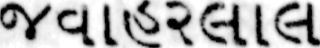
જવાહરલાલ
